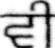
ਵੀ
